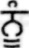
ਨੂੰ
